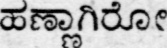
ಹಣ್ಣಾಗಿರೋ
